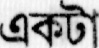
একটা
